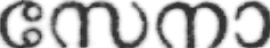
സേനാ
